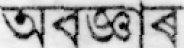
অবজ্ঞাৰ
